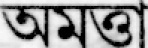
অমত্তা
